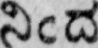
ನಿಂದ
